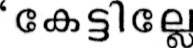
'കേട്ടില്ലേ
